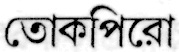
তোকপিরো
